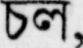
চল,
